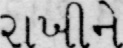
રાખીને
